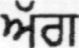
ਅੱਗ
